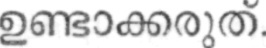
ഉണ്ടാക്കരുത്.
